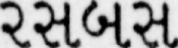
રસબસ
